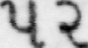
પર
